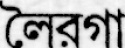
লৈরগা
